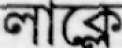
লাক্লে
